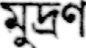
মুদ্রণ
